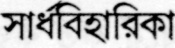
সার্ধবিহারিকা
